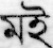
মই
